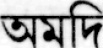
অমদি
